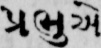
પ્રભુએ
